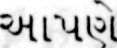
આપણે
